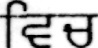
ਵਿਚ
